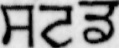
ਸਟਡ
